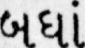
બધાં
